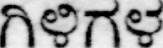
ಗಿಳಿಗಳ
